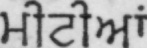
ਮੀਟੀਆਂ
